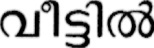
വീട്ടില്‍
